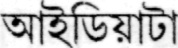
আইডিয়াটা
